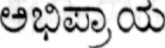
ಅಭಿಪ್ರಾಯ
